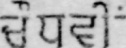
ਚੌਧਵੀਂ
